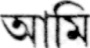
আমি
